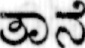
ತಾನೆ
